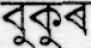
বুকুৰ
